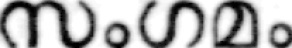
സംഗമം
